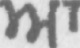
ਆ
